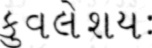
કુવલેશયઃ
